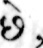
છે,
